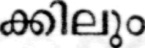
ക്കിലും
